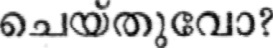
ചെയ്തുവോ?
